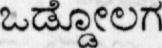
ಒಡ್ಡೋಲಗ
